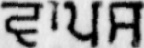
ਵਾਪਸ
